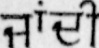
ਜਾਂਦੀ
